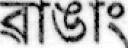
ৱাঙাং
